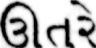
ઊતરે
